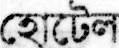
হোটেল
